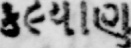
કલ્યાણ
